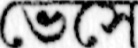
ভেসে
